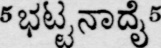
5ಭಟ್ಟನಾದೈ5
